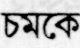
চমকে
